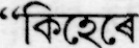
"কিহেৰে
